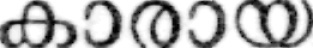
കാരായ
